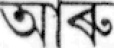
আৰু
